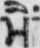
ਮੈਂ
